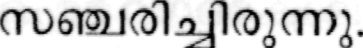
സഞ്ചരിച്ചിരുന്നു.
